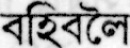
বহিবলৈ
